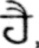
ਹੈ,
